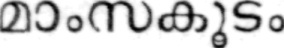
മാംസകൂടം
